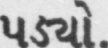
પડ્યો.
